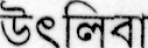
উৎলিবা
